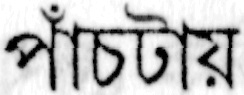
পাঁচটায়
